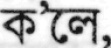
ক'লে,
